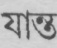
যান্ত
